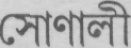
সোণালী
